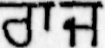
ਰਾਜ
